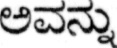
ಅವನ್ನು
